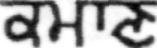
ਕਮਾਣ
